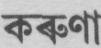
কৰুণা
